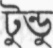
টুন্ডু
